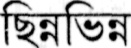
ছিন্নভিন্ন
